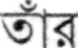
তাঁর
